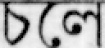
চলে
